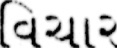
વિચાર
